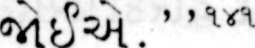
જોઈએ."૧૪૧
